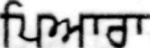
ਪਿਆਰਾ
